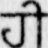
ਹੀ
